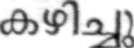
കഴിച്ചു
